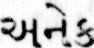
અનેક
